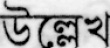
উল্লেখ
